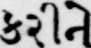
કરીને
